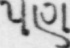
પણ
